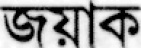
জয়াক
